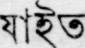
যাইত
